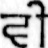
ਵੀ
